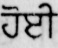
ਹੋਈ
